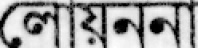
লোয়ননা
